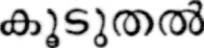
കൂടുതല്‍
